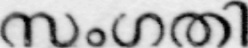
സംഗതി
